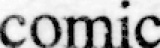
comic
